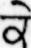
ਕੇ
